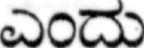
ಎಂದು
